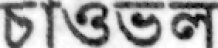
চাওভল
